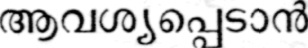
ആവശ്യപ്പെടാന്‍
